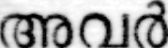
അവര്‍
